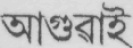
আগুৱাই
